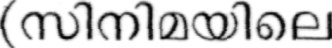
(സിനിമയിലെ
